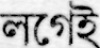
লগেই
